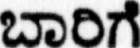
ಬಾರಿಗೆ
